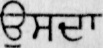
ਉਸਦਾ
